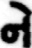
ને
